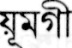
য়ূমগী
